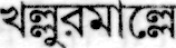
খল্লুরমাল্লে
